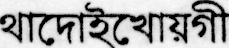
থাদোইখোয়গী
